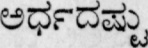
ಅರ್ಧದಷ್ಟು
